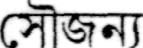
সৌজন্য
